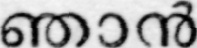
ഞാന്‍
